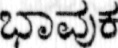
ಭಾವುಕ
